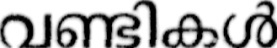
വണ്ടികള്‍
